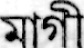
মাগী
